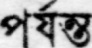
পর্যন্ত
